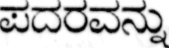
ಪದರವನ್ನು
